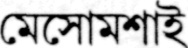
মেসোমশাই
